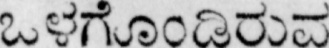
ಒಳಗೊಂಡಿರುವ
